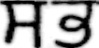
ਸਭ
